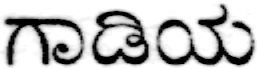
ಗಾಡಿಯ
